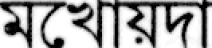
মখোয়দা
